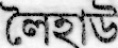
লৈহাউ
